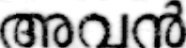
അവന്‍
